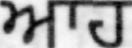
ਆਹ
